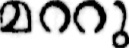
മററു
